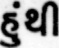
હુંથી
